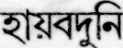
হায়বদুনি
